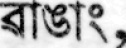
ৱাঙাং,
